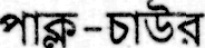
পাক্ল-চাউরবা
